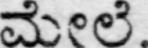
ಮೇಲೆ.
